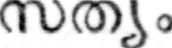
സത്യം
